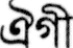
ঐগী
